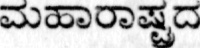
ಮಹಾರಾಷ್ಟ್ರದ
